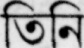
তিনি
